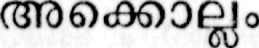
അക്കൊല്ലം
